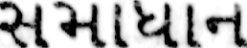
સમાધાન
